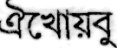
ঐখোয়বু
